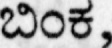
ಬಿಂಕ,
